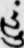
હું
